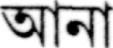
আনা
